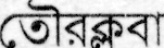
তৌরক্লবা
